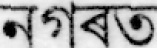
নগৰত
